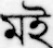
মই
